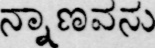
ನ್ನಾಣವನು
